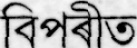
বিপৰীত
